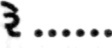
રે.........
